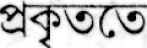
প্রকৃততে
